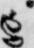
હું
